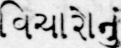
વિચારોનું
